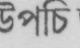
উপচি
